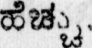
ಹೆಚ್ಚು.
